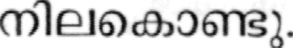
നിലകൊണ്ടു.
